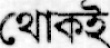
থোকই
